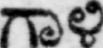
ಗಾಳಿ
